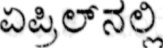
ಏಪ್ರಿಲ್ ನಲ್ಲಿ
